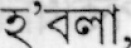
হ'বলা,
